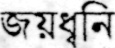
জয়ধ্বনি
